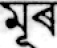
মূৰ
